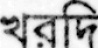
খরদি
